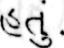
હતું.
